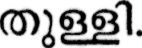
തുള്ളി.
